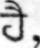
ਹੈ,
